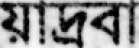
য়াদ্রবা
